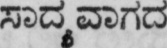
ಸಾದ್ಯವಾಗದ
